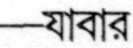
–যাবার
